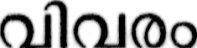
വിവരം
